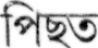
পিছত
